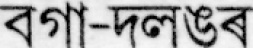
বগা-দলঙৰ
